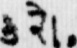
કરો.
